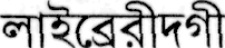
লাইব্রেরীদগী
